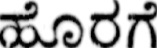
ಹೊರಗೆ
